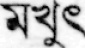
মখুৎ
